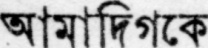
আমাদিগকে
